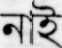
নাই
